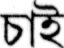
চাই
